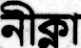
নীক্না
